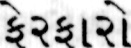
ફેરફારો
